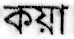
কয়া
